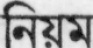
নিয়ম
